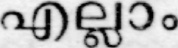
എല്ലാം
